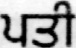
ਪਤੀ
